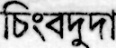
চিংবদুদা
